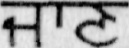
ਜਾਣ
